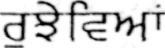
ਰੁਝੇਵਿਆਂ
